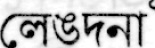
লেঙদনা
